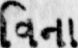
વિના
